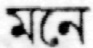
মনে
